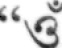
"ওঁ
